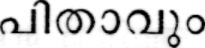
പിതാവും
